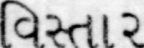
વિસ્તાર
